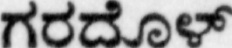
ಗರದೊಳ್
